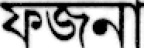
ফজনা
